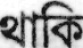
থাকি
